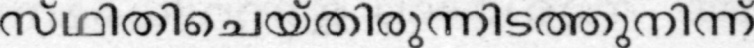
സ്ഥിതിചെയ്തിരുന്നിടത്തുനിന്ന്
